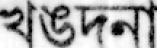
খঙদনা
